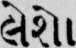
લેશો
